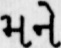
મને
